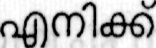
എനിക്ക്
